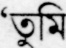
‘তুমি
